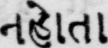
નહોતા
